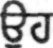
ਉਹ
